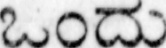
ಒಂದು
